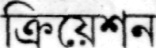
ক্রিয়েশন
